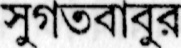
সুগতবাবুর
